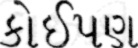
કોઈપણ
